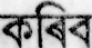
কৰিব
